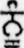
ਨੂੰ
